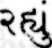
રહ્યું
